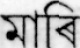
মাৰি
